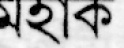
মহাক
